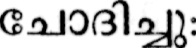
ചോദിച്ചു:
